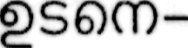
ഉടനെ-
